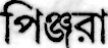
পিঞ্জরা
